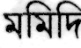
মমিদি
